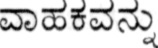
ವಾಹಕವನ್ನು
